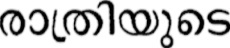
രാത്രിയുടെ
